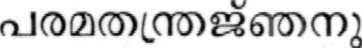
പരമതന്ത്രജ്ഞനു
